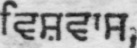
ਵਿਸ਼ਵਾਸ;
